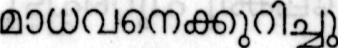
മാധവനെക്കുറിച്ചു
